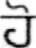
ਹੋ
